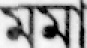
মমা
